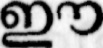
ഈ
